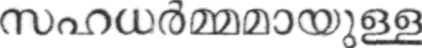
സഹധര്‍മ്മമായുള്ള
